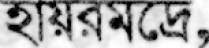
হায়রমদ্রে,
